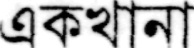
একখানা
